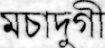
মচাদুগী
